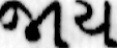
જાય
